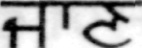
ਜਾਣ
